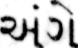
અંગે
